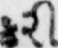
કરી
